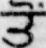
ਤੋਂ
